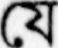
যে
